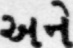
અને
